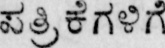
ಪತ್ರಿಕೆಗಳಿಗೆ
